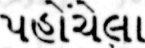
પહોંચેલા
